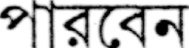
পারবেন
